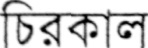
চিরকাল
